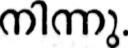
നിന്നു.
